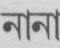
নানা
